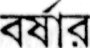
বর্ষার
